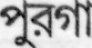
পুরগা
